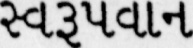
સ્વરૂપવાન
